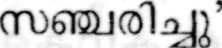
സഞ്ചരിച്ചു’
